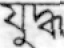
যুদ্ধ
